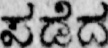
ಪಡೆದ
